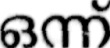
ഒന്ന്
